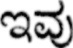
ಇವು
